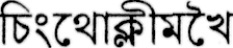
চিংথোক্লীমখৈ
